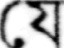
যে
